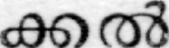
ക്കല്‍
